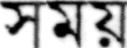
সময়
